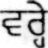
ਵਰ੍ਹੇ
